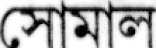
সোমাল
